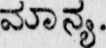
ಮಾನ್ಯ.
